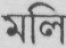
মলি
